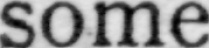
some
